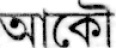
আকৌ
